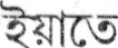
ইয়াতে
